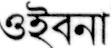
ওইবনা
